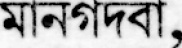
মানগদবা,
